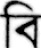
বি
